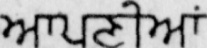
ਆਪਣੀਆਂ
